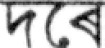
দৰে
